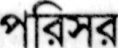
পরিসর
